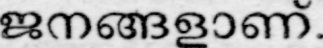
ജനങ്ങളാണ്.
